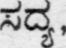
ಸದ್ಯ,
